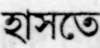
হাসতে
